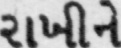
રાખીને
